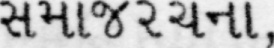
સમાજરચના,
